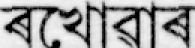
ৰখোৱাৰ
